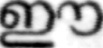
ഈ
